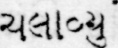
ચલાવ્યું:
